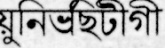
য়ুনিভর্ছিটীগী
